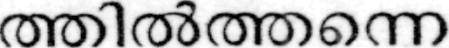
ത്തില്‍ത്തന്നെ
